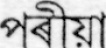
পৰীয়া
